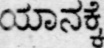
ಯಾನಕ್ಕೆ
